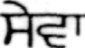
ਸੇਵਾ
